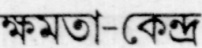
ক্ষমতা-কেন্দ্র
